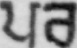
ਪਰ
